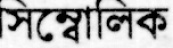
সিম্বোলিক
